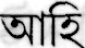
আহি
